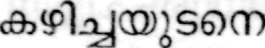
കഴിച്ചയുടനെ
